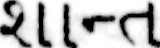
શાન્ત
